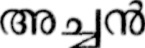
അച്ചന്‍
